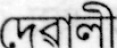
দেৱালী
